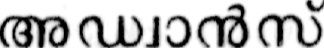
അഡ്വാന്‍സ്
